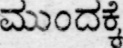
ಮುಂದಕ್ಕೆ
